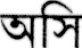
অসি
